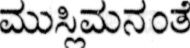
ಮುಸ್ಲಿಮನಂತೆ
